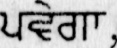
ਪਵੇਗਾ,
